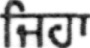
ਜਿਹਾ
